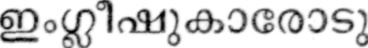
ഇംഗ്ലീഷുകാരോടു
